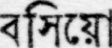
বসিয়ো
